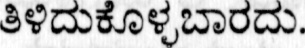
ತಿಳಿದುಕೊಳ್ಳಬಾರದು.
